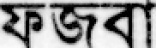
ফজবা
